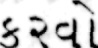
કરવો
